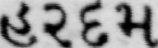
હરદમ
